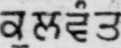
ਕੁਲਵੰਤ
